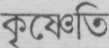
কৃষ্ণেতি
